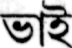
ভাই
